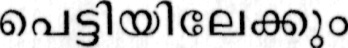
പെട്ടിയിലേക്കും
